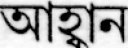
আহ্বান
